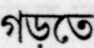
গড়তে
